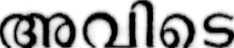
അവിടെ
